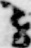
કે
